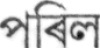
পৰিল
